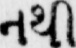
નથી
